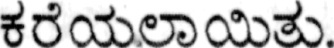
ಕರೆಯಲಾಯಿತು.
